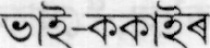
ভাই-ককাইৰ
